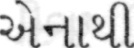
એનાથી
